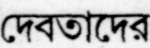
দেবতাদের
